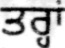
ਤਰ੍ਹਾਂ
